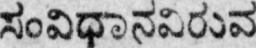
ಸಂವಿಧಾನವಿರುವ
